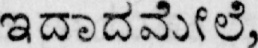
ಇದಾದಮೇಲೆ,
